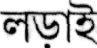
লড়াই
